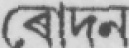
ৰোদন
